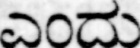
ಎಂದು
